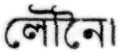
লৌনৈ।
